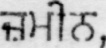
ਜ਼ਮੀਨ,
